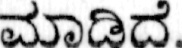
ಮಾಡಿದೆ.
